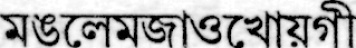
মঙলেমজাওখোয়গী
